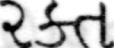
રક્ત
